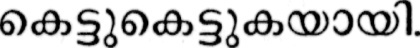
കെട്ടുകെട്ടുകയായി.
